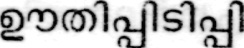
ഊതിപ്പിടിപ്പി
